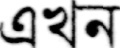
এখন
